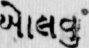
બોલવું
